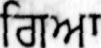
ਗਿਆ
